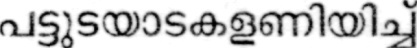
പട്ടുടയാടകളണിയിച്ച്
